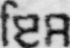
ਇਸ
